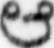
ಆ
